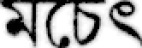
মচেৎ
